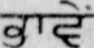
ਭਾਵੇਂ
